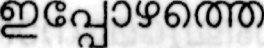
ഇപ്പോഴത്തെ
